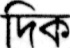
দিক
